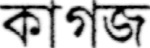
কাগজ
